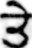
ਤੇ
